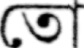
তো
